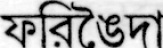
ফরিঙৈদা
